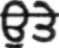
ਉਤੇ
